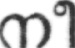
നീ
